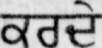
ਕਰਦੇ
